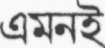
এমনই
